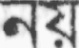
নয়
